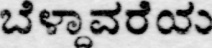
ಬೆಳ್ದಾವರೆಯ
